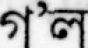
গ'ল
